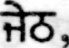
ਜੇਠ,
